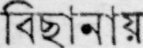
বিছানায়
